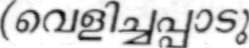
(വെളിച്ചപ്പാടു
